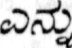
ಎನ್ನು
